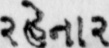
રહેનાર
